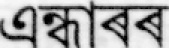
এন্ধাৰৰ
